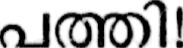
പത്തി!
